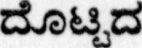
ದೊಟ್ಟಿದ
